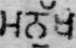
ਮਨੁੱਖ
